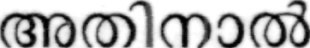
അതിനാല്‍
